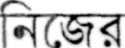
নিজের
